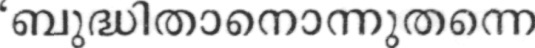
'ബുദ്ധിതാനൊന്നുതന്നെ
